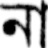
না
